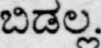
ಬಿಡಲ್ಲ.
